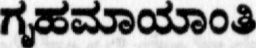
ಗೃಹಮಾಯಾಂತಿ
